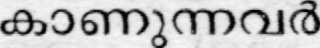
കാണുന്നവര്‍
